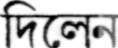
দিলেন
